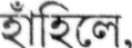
হাঁহিলে,
